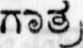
ಗಾತ್ರ
